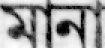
মানা
